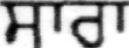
ਸਾਰਾ
